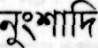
নুংশাদি
